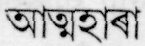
আত্মহাৰা
